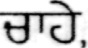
ਚਾਹੇ,
